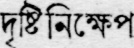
দৃষ্টিনিক্ষেপ
